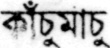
কাঁচুমাচু
